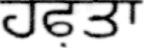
ਹਫ਼ਤਾ
